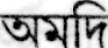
অমদি
